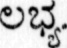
ಲಭ್ಯ.
